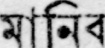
মানিব
